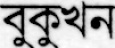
বুকুখন
